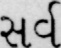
સર્વ
